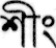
শীং
